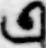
এ
